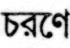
চরণে
